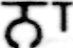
ਨਾ
